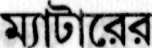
ম্যাটারের
